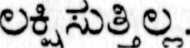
ಲಕ್ಷಿಸುತ್ತಿಲ್ಲ.
